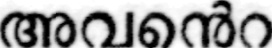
അവന്റെ
